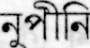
নুপীনি
